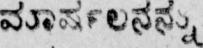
ಮಾರ್ಷಲನನ್ನು
